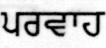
ਪਰਵਾਹ
